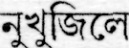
নুখুজিলে
